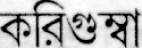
করিগুম্বা
